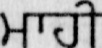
ਮਾਹੀ
